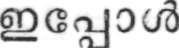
ഇപ്പോള്‍
